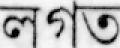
লগত
